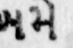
અમે
